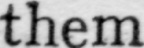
them
